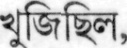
খুজিছিল,
